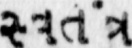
સ્વતંત્ર
